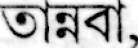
তান্নবা,
